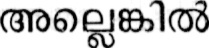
അല്ലെങ്കില്‍
